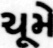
ચૂમે
